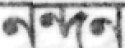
নন্দন
